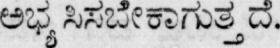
ಅಭ್ಯಸಿಸಬೇಕಾಗುತ್ತದೆ.
